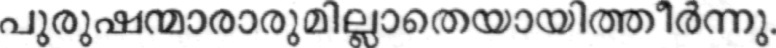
പുരുഷന്മാരാരുമില്ലാതെയായിത്തീര്‍ന്നു.
